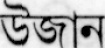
উজান
